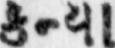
કન્યા
